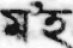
ম'হ
